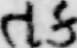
તક
